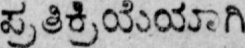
ಪ್ರತಿಕ್ರಿಯೆಯಾಗಿ
